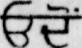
ਓਦੋਂ
